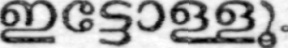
ഇട്ടോള്ളൂ.
